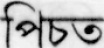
পিচত
